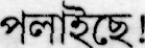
পলাইছে!
